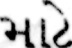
માટે
